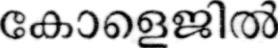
കോളെജില്‍
